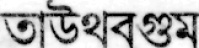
তাউথবগুম
